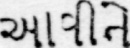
આવીને
